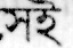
সেই
